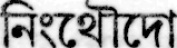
নিংথৌদো
